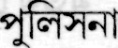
পুলিসনা
